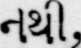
નથી,
